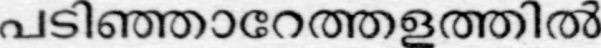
പടിഞ്ഞാറേത്തളത്തില്‍
